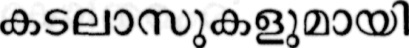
കടലാസുകളുമായി
